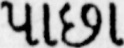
પાછા
